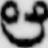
ಆ
